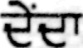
ਦੇਂਦਾ
